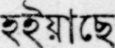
হইয়াছে
